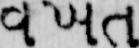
વખત
